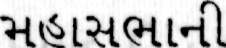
મહાસભાની
